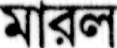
মারল
